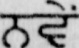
ਨਵੇਂ
